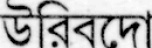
উরিবদো
